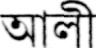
আলী
